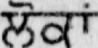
ਲੋਕਾਂ
